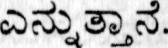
ಎನ್ನುತ್ತಾನೆ.
